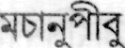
মচানুপীবু
